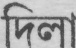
দিলা
